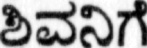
ಶಿವನಿಗೆ
